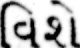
વિશે
